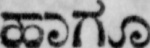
ಹಾಗೂ
